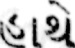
હાથે
